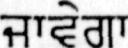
ਜਾਵੇਗਾ
